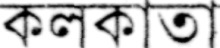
কলকাতা
